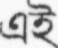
এই
